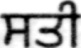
ਸਤੀ
